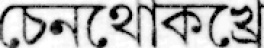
চেনথোকখ্রে
